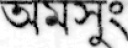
অমসুং
